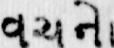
વચનો
